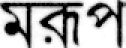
মরূপ
